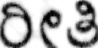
ರೀತಿ
